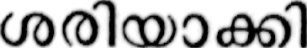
ശരിയാക്കി
